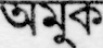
অমুক
